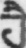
ਹੈ
